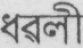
ধৱলী
